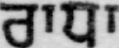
ਰਾਧਾ
